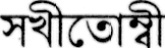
সখীতোম্বী
